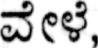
ವೇಳೆ,
